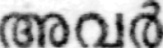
അവര്‍
